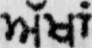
ਅੱਖਾਂ
